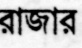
রাজার
